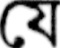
যে
